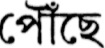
পৌঁছে
